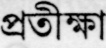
প্রতীক্ষা
